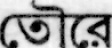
তৌরে
